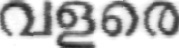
വളരെ
